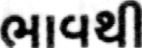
ભાવથી
